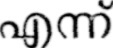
എന്ന്
